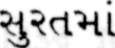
સુરતમાં
